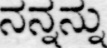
ನನ್ನನ್ನು
